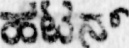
ಹಟನ್
